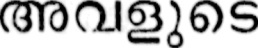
അവളുടെ
